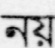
নয়
